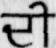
ਦੀ
